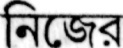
নিজের
